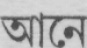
আনে
